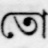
তো
